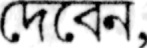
দেবেন,
